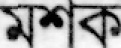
মশক
